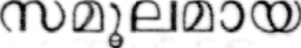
സമൂലമായ
